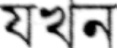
যখন
